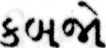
કબજો
